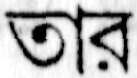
তার
